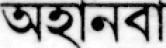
অহানবা
